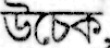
উচেক,
